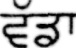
ਵੱਡਾ
